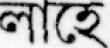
লাহে
